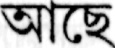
আছে
